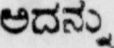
ಅದನ್ನು
